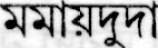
মমায়দুদা
